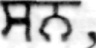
ਸਨ,
